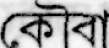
কৌবা
